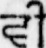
ਵੀ
